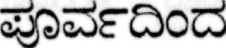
ಪೂರ್ವದಿಂದ
